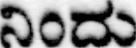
ನಿಂದು
